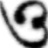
ও
